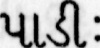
પાડી:
